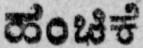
ಹಂಚಿಕೆ
